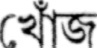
খোঁজ
